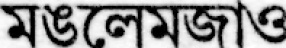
মঙলেমজাও
